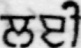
ਲਈ
